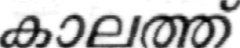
കാലത്ത്
